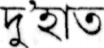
দু’হাত
